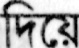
দিয়ে
